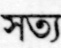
সত্য
